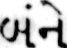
બંને
